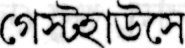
গেস্টহাউসে
